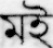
মই
